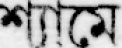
শ্যামে
